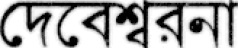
দেবেশ্বরনা
